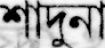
শাদুনা
